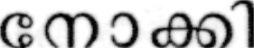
നോക്കി
